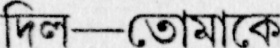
দিল-তোমাকে
